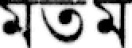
মতম
